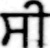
ਸੀ
